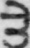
ਤੇ
